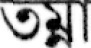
তম্না
